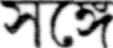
সঙ্গে
